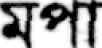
মপা
